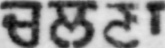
ਚਲਣਾ
